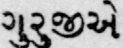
ગુરુજીએ
